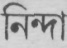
নিন্দা
